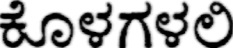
ಕೊಳಗಳಲಿ
